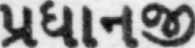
પ્રધાનજી
